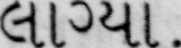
લાગ્યા.
